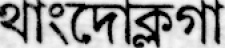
থাংদোক্লগা
